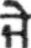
ਜੇ
